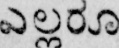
ಎಲ್ಲರೂ
